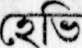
হেভি
